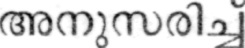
അനുസരിച്ച്
